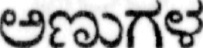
ಅಣುಗಳ
